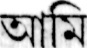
আমি
